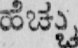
ಹೆಚ್ಚು
